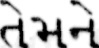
તેમને
